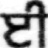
ਈ
